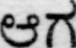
ಆಗ
